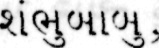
શંભુબાબુ,
